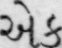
એક
